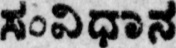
ಸಂವಿಧಾನ
